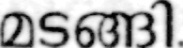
മടങ്ങി.
